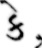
કે,
